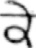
ਕੇ
